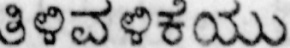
ತಿಳಿವಳಿಕೆಯು
